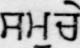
ਸਮੁਚੇ
